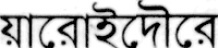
য়ারোইদৌরে
